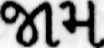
જામ
